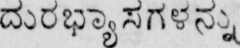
ದುರಭ್ಯಾಸಗಳನ್ನು
